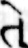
તે
